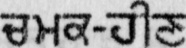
ਚਮਕ-ਹੀਣ
